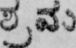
ಶ್ರಮ
